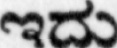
ಇದು
